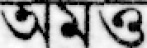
অমত্ত
